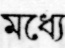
মধ্যে
